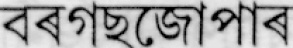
বৰগছজোপাৰ
